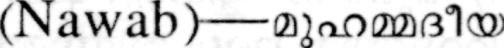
(Nawab)-മുഹമ്മദീയ
